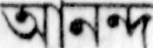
আনন্দ
